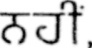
ਨਹੀਂ
